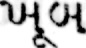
ખૂબ
